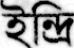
ইন্দ্রি
